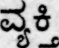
ವ್ಯಕ್ತಿ
